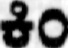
ಕಿಂ
